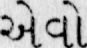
એવો
